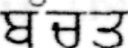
ਬੱਚਤ
